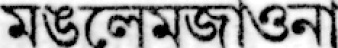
মঙলেমজাওনা
